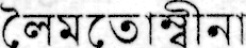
লৈমতোম্বীনা
